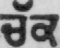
ਚੱਕ
